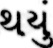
થયું
